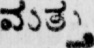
ಮತ್ತು
